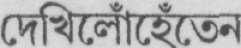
দেখিলোঁহেঁতেন
